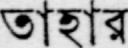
তাহার
